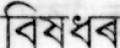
বিষধৰ
